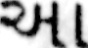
આ
